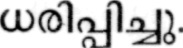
ധരിപ്പിച്ചു.
